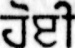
ਹੋਈ
